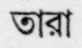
তারা
